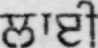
ਲਾਈ
